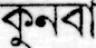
কুনবা
